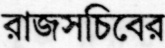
রাজসচিবের
